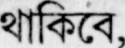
থাকিবে,
